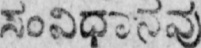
ಸಂವಿಧಾನವು
